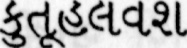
કુતૂહલવશ
